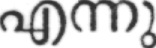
എന്നു
